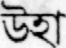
উহা
